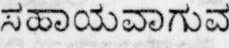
ಸಹಾಯವಾಗುವ
